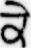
ਕੇ
